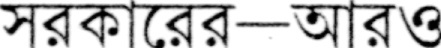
সরকারের–আরও
